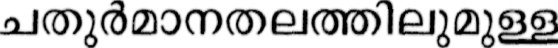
ചതുര്‍മാനതലത്തിലുമുള്ള
